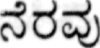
ನೆರವು
